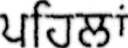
ਪਹਿਲਾਂ
